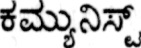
ಕಮ್ಯುನಿಸ್ಟ್
